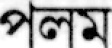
পলম
